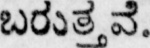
ಬರುತ್ತವೆ.
